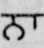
ਨਾ
